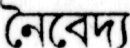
নৈবেদ্য
